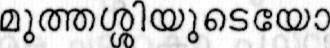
മുത്തശ്ശിയുടെയോ
